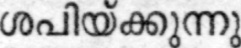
ശപിയ്ക്കുന്നു
